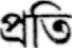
প্রতি
